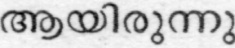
ആയിരുന്നു
